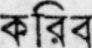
করিব
